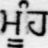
ਮੂੰਹ
